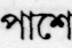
পাশে
